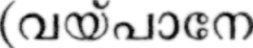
(വായ്പാനേ
